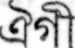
ঐগী
